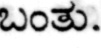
ಬಂತು.
